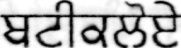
ਬਟੀਕਲੋਏ
